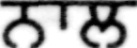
ਨਾਲ
